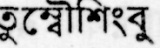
তুম্বৌশিংবু
